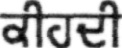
ਕੀਹਦੀ
